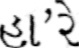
હા`રે
